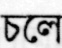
চলে
